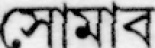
সোমাব
